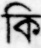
কি
